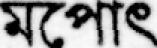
মপোৎ
